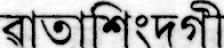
ৱাতাশিংদগী
